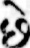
છે
